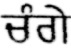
ਚੰਗੇ
